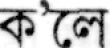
ক'লে
